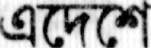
এদেশে
